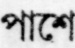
পাশে
